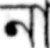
না
